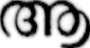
ആ
